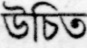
উচিত
